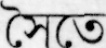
সৈতে
